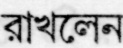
রাখলেন
